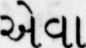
એવા
